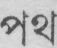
পথ
